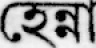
হেন্না
